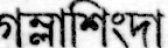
গম্লাশিংদা
